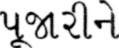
પૂજારીને
